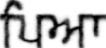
ਪਿਆ
